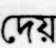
দেয়
